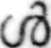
ള്‍
